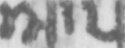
ਆਪ
